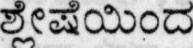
ಶ್ಲೇಷೆಯಿಂದ
